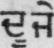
ਦੂਜੇ
